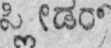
ಪ್ಲೀಡರ್
